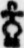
ਨੂੰ
